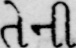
તેની
